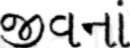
જીવનાં
